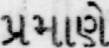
પ્રમાણે
